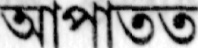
আপাতত
